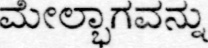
ಮೇಲ್ಭಾಗವನ್ನು
